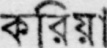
করিয়া
